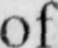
of
